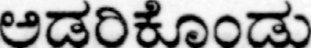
ಅಡರಿಕೊಂಡು
